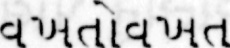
વખતોવખત
